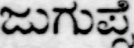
ಜಿಗುಪ್ಸೆ
